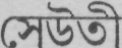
সেউতী
